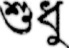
শুধু
